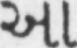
આ
